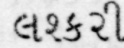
લશ્કરી
